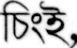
চিংই,
